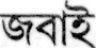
জবাই
